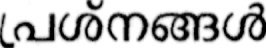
പ്രശ്നങ്ങള്‍
